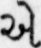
એ
